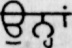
ਉਨ੍ਹਾਂ
